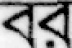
বর
